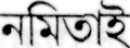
নমিতাই
